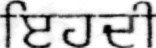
ਇਹਦੀ
